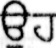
ਉਹ
